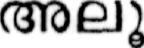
അലൂ
